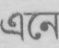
এনে
